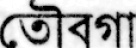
তৌবগা
